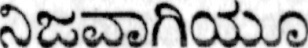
ನಿಜವಾಗಿಯೂ
